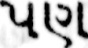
પણ
